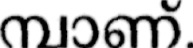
മ്പാണ്.
